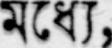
মধ্যে,
